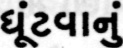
ધૂંટવાનું
